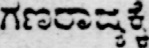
ಗಣರಾಜ್ಯಕ್ಕೆ
